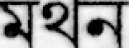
মথন
